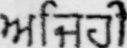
ਅਜਿਹੀ
